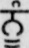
ਨੂੰ
